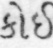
કોઈ
